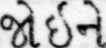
જોઈને
